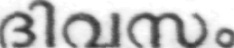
ദിവസം
